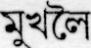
মুখলৈ
